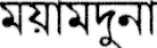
ময়ামদুনা
